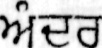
ਅੰਦਰ
